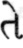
તે
